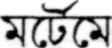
মর্টেমে
